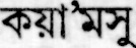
কয়া’মসু
